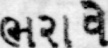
ભરાવે
